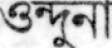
ওন্দুনা
